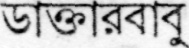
ডাক্তারবাবু
